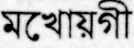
মখোয়গী
